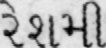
રેશમી
